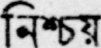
নিশ্চয়
